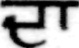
ਦਾ
